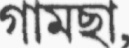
গামছা,
